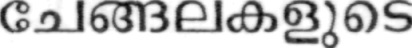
ചേങ്ങലകളുടെ
